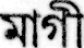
মাগী
